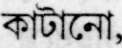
কাটানো,
